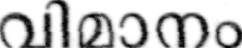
വിമാനം
